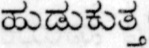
ಹುಡುಕುತ್ತ
